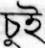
চুই
